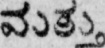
ಮತ್ತು
